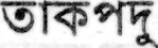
তাকপদু
